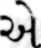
એ
